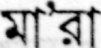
মা’রা
